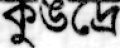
কুঙদ্রে
